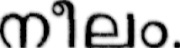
നീലം.
